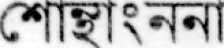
শোন্থাংননা
